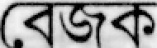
বেজক
